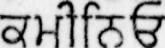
ਕਮੀਨਿਓ
